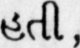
હતી,
